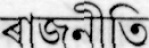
ৰাজনীতি
